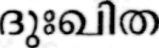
ദുഃഖിത
